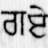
ਗਏ
